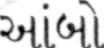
આંબો
